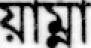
য়াম্না
